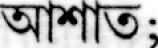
আশাত;
